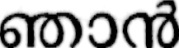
ഞാന്‍
